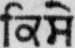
ਕਿਸੇ
